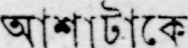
আশাটাকে
